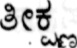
ತೀಕ್ಷ್ಣ
